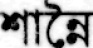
শান্নৈ
